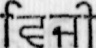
ਵਿਜੀ
